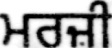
ਮਰਜ਼ੀ
